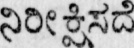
ನಿರೀಕ್ಷಿಸದೆ
